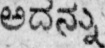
ಅದನ್ನು
